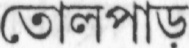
তোলপাড়
